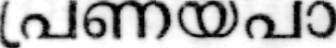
പ്രണയപാ
